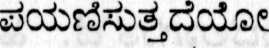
ಪಯಣಿಸುತ್ತದೆಯೋ
